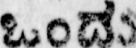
ಒಂದು
